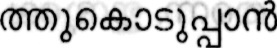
ത്തുകൊടുപ്പാന്‍
